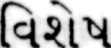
વિશેષ
